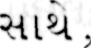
સાથે,
